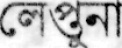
লেপ্তুনা
